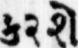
કરશે
